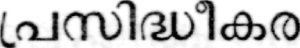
പ്രസിദ്ധീകര
